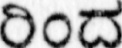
ರಿಂದ
